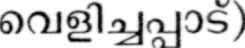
വെളിച്ചപ്പാട്)
